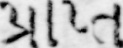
પ્રાપ્ત
